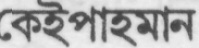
কেইপাহমান
